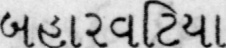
બહારવટિયા
